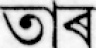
তাৰ
